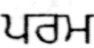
ਪਰਮ
